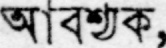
আবশ্যক,
